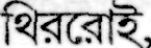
থিররোই,
